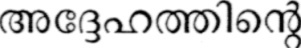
അദ്ദേഹത്തിന്റെ
